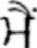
ਮੈਂ
